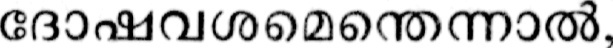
ദോഷവശമെന്തെന്നാല്‍,
